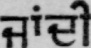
ਜਾਂਦੀ
